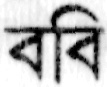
ববি
